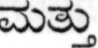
ಮತ್ತು
